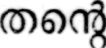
തന്റെ
